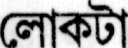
লোকটা
